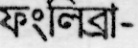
ফংলিব্রা-
